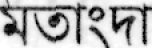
মতাংদা
